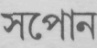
সপোন
